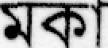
মকা
